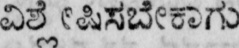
ವಿಶ್ಲೇಷಿಸಬೇಕಾಗು
